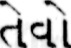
તેવો
